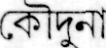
কৌদুনা
